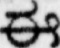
ಈ
